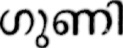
ഗുണി
